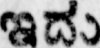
ಇದು
